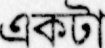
একটা
